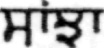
ਸਾਂਝਾ
